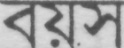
বয়স
